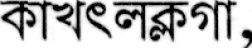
কাখৎলক্লগা,
